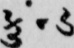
કુંન્ડ
